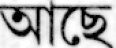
আছে
